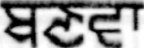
ਬਣਵਾ
